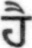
ਹੈ
